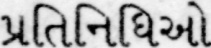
પ્રતિનિધિઓ
